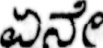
ಏನೇ
